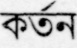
কর্তন
